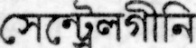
সেন্ট্রেলগীনি
